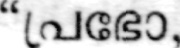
“പ്രഭോ,
